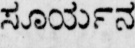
ಸೂರ್ಯನ
